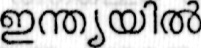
ഇന്ത്യയില്‍
